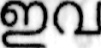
ഇവ
